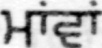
ਮਾਂਵਾਂ
